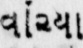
વાંચ્યા
